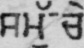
ਸਮੁੱਚੇ
